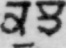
ਕੁਝ
